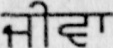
ਜੀਵਾ
